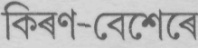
কিৰণ-বেশেৰে
